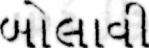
બોલાવી
